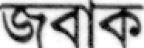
জবাক
